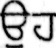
ਉਹ
